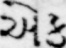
એક
